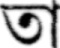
তা
